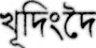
খূদিংদৈ
